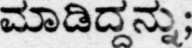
ಮಾಡಿದ್ದನ್ನು;
